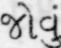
જોવું
